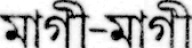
মাগী-মাগী
